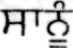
ਸਾਨੂੰ
